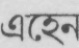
এহেন
